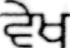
ਵੇਖ
